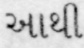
આથી
